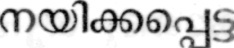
നയിക്കപ്പെട്ട
